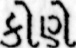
કોણે
